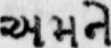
અમને
